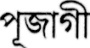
পুজাগী
